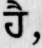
ਹੈ,
